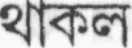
থাকল
